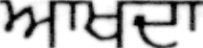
ਆਖਦਾ
